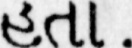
હતા.
